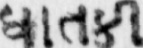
ઘાતકી
